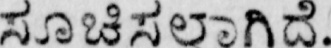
ಸೂಚಿಸಲಾಗಿದೆ.
